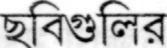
ছবিগুলির
